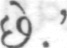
છે.'
